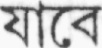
যাবে
